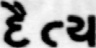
દૈત્ય
